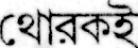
থোরকই
